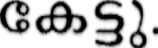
കേട്ടു.
